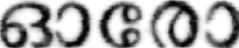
ഓരോ
